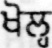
ਖੋਲ੍ਹ
